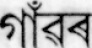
গাঁৱৰ
